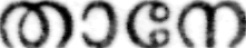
താനേ
